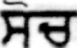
ਸੋਚ
